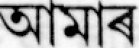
আমাৰ
